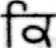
ਕਿ
